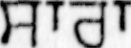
ਸਾਰਾ
